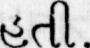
હતી.
